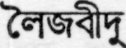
লৈজবীদু
